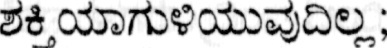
ಶಕ್ತಿಯಾಗುಳಿಯುವುದಿಲ್ಲ;
